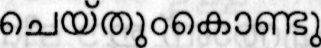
ചെയ്തുംകൊണ്ടു
